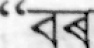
"বৰ
